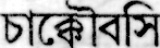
চাক্কৌবসি
